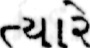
ત્યારે
